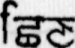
ਛਿਣ
